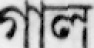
গাল
